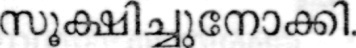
സൂക്ഷിച്ചുനോക്കി.
